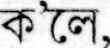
ক'লে,
